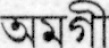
অমগী
